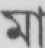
মা
